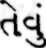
તેવું
